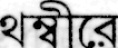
থম্বীরে
